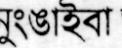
নুংঙাইবা
